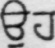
ਉਹ
